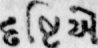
દષ્ટિએ
